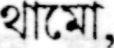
থামো,
